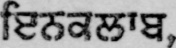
ਇਨਕਲਾਬ,
